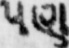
પણ
